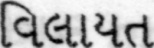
વિલાયત
